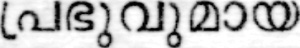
പ്രഭുവുമായ
